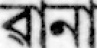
ৱানা
